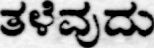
ತಳೆವುದು
